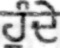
ਹੁੰਦੇ
